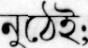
নুঠেই;
